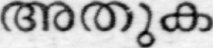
അതുക
